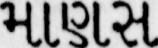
માણસ
